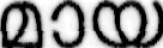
മായ
